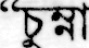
“চুম্না
